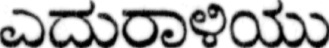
ಎದುರಾಳಿಯು
